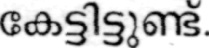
കേട്ടിട്ടുണ്ട്.
